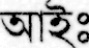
আইঃ
